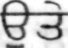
ਉਤੇ
